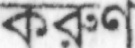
করুণ
